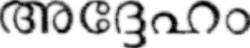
അദ്ദേഹം
